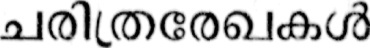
ചരിത്രരേഖകള്‍
